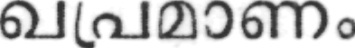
ഖപ്രമാണം
